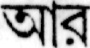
আর
